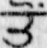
ਤੋਂ
